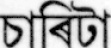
চাৰিটা
